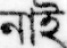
নাই
